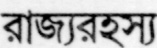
রাজ্যরহস্য
